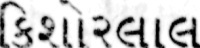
કિશોરલાલ
